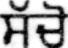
ਸੱਚੋ
